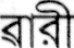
ৱারী
